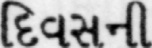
દિવસની
